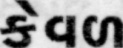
કેવળ
